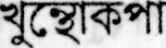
খুন্থোকপা
